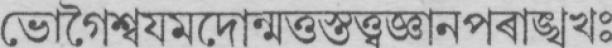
ভোগৈশ্বযমদোন্মত্তস্তত্ত্বঞ্জানপৰাঙ্খখঃ
